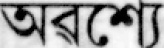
অৱশ্যে
